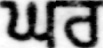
ਘਰ
